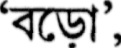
'বড়ো',
